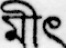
মীৎ
